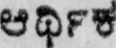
ಆರ್ಥಿಕ
